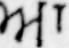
ਆ
